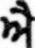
ਐ
